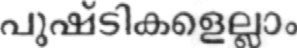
പുഷ്ടികളെല്ലാം
